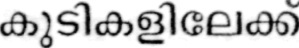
കുടികളിലേക്ക്
